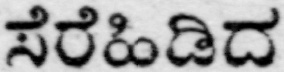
ಸೆರೆಹಿಡಿದ
